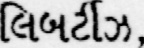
લિબર્ટીઝ,
